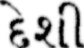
દેશી
